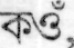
কওঁ,
